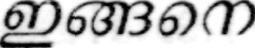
ഇങ്ങനെ
